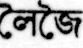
লৈজৈ
